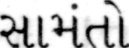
સામંતો
